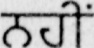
ਨਹੀਂ
